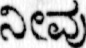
ನೀವು
